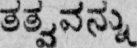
ತತ್ವವನ್ನು
